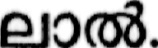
ലാല്‍.
